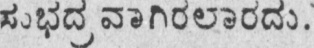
ಸುಭದ್ರವಾಗಿರಲಾರದು.
